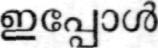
ഇപ്പോള്‍
